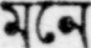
মনে
